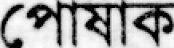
পোষাক
